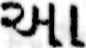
આ
